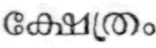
ക്ഷേത്രം
